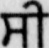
ਸੀ
